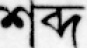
শব্দ
